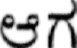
ಆಗ
